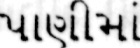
પાણીમાં
